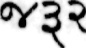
જરૂર
